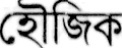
হৌজিক
